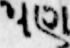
પણ
